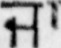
ਜਾ
